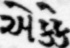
એક્કે
